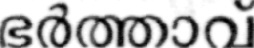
ഭര്‍ത്താവ്
